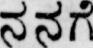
ನನಗೆ
